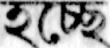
হচ্ছে
